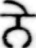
ਨੇ
